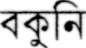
বকুনি
